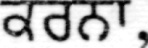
ਕਰਨਾ,
